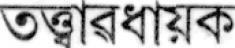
তত্ত্বাৱধায়ক
